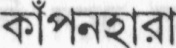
কাঁপনহারা
